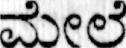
ಮೇಲೆ
